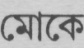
মোকে
